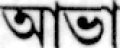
আভা
